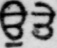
ਉਤੇ
